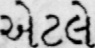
એટલે
